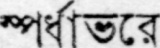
স্পর্ধাভরে
